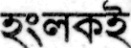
হংলকই
